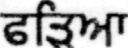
ਫੜਿਆ
